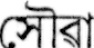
সৌৱা
